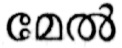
മേല്‍
